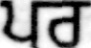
ਪਰ
